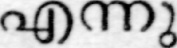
എന്നു
